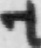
ન
